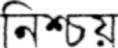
নিশ্চয়
